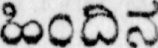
ಹಿಂದಿನ
